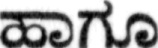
ಹಾಗೂ
